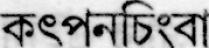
কৎপনচিংবা
